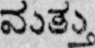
ಮತ್ತು
